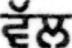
ਵੱਲ
